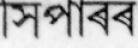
সিপাৰৰ
